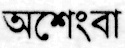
অশেংবা
